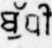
ਬੁੱਧੀ
